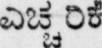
ಎಚ್ಚರಿಕೆ
